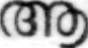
ആ
